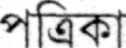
পত্রিকা
